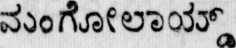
ಮಂಗೋಲಾಯ್ಡ್
